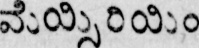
ಮೆಯ್ಸಿರಿಯಿಂ
